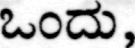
ಒಂದು,
